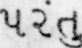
પરંતુ
